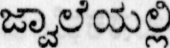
ಜ್ವಾಲೆಯಲ್ಲಿ
